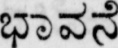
ಭಾವನೆ
